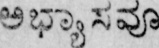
ಅಭ್ಯಾಸವೂ
